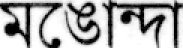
মঙোন্দা
